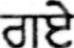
ਗਏ
